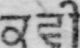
ਕਵੀ
